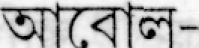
আবোল-
